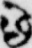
છે
